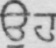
ਉਹ
